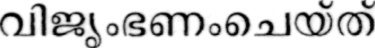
വിജൃംഭണംചെയ്ത്
